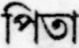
পিতা
